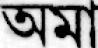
অমা
